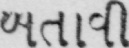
બતાવી
